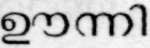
ഊന്നി
